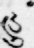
હું
